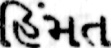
હિંમત
